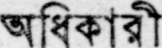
অধিকারী
